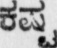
ಕಷ್ಟ
